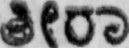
ತೀರಾ
